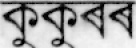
কুকুৰৰ
